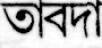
তাবদা
